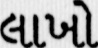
લાખો
